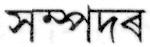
সম্পদৰ
